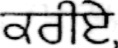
ਕਰੀਏ,
